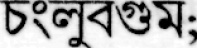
চংলুবগুম;
